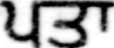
ਪਤਾ
